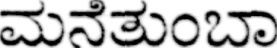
ಮನೆತುಂಬಾ
